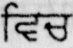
ਵਿਚ
